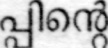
പ്പിന്റെ
